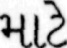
માટે
